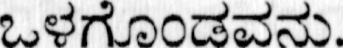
ಒಳಗೊಂಡವನು.
